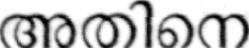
അതിനെ
